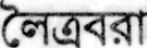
লৈত্রবরা
